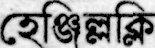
হেঞ্জিল্লক্লি
